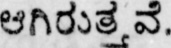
ಆಗಿರುತ್ತವೆ.
